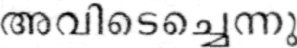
അവിടെച്ചെന്നു
